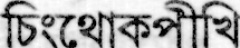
চিংথোকপীখি
